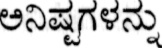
ಅನಿಷ್ಟಗಳನ್ನು
